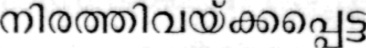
നിരത്തിവയ്ക്കപ്പെട്ട
